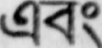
এবং
